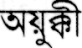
অয়ুক্কী
